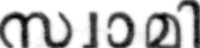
സ്വാമി
